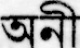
অনী
